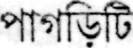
পাগড়িটি
